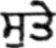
ਸੁਤੇ
